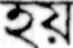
হয়
